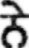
ਨੇ
